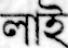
লাই
